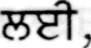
ਲਈ,
